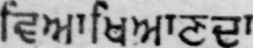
ਵਿਆਖਿਆਣਦਾ
